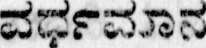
ವರ್ಧಮಾನ
